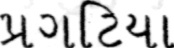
પ્રગટિયા
